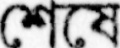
শেষে
